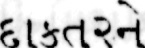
દાકતરને
